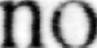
no
